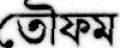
তৌফম
